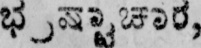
ಭ್ರಷ್ಟಾಚಾರ,
